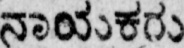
ನಾಯಕರು
